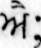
ਐ;
